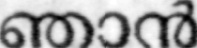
ഞാന്‍
